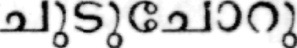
ചുടുചോറു
